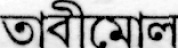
তাবীমোল
